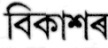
বিকাশৰ
